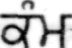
ਕੰਮ
